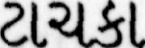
ટાચકા
